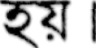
হয়।
